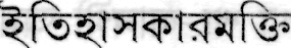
ইতিহাসকারমক্তি
